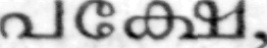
പക്ഷേ,
